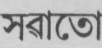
সৱাতো
